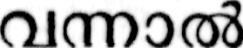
വന്നാല്‍
